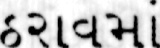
ઠરાવમાં
